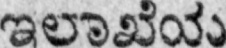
ಇಲಾಖೆಯ
